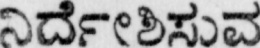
ನಿರ್ದೇಶಿಸುವ
